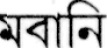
মবানি
